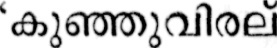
‘കുഞ്ഞുവിരല്
